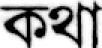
কথা
